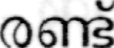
രണ്ട്
